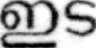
ഇട
